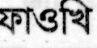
ফাওখি
